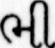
ભી
